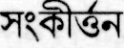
সংকীর্ত্তন
